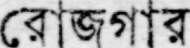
রোজগার
